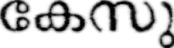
കേസു
